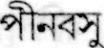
পীনবসু
